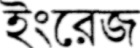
ইংরেজ
